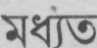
মধ্যত
